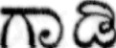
ಗಾಡಿ
